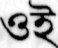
ওই
